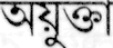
অয়ুক্তা
